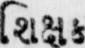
શિક્ષક
